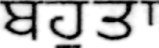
ਬਹੁਤਾ
